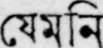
যেমনি
